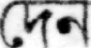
দেন
